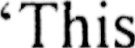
'This
